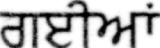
ਗਈਆਂ
